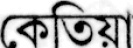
কেতিয়া
